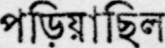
পড়িয়াছিল
